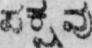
ಪಕ್ಷವು
